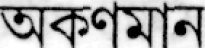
অকণমান
